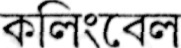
কলিংবেল
